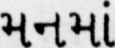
મનમાં
